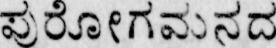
ಪುರೋಗಮನದ
